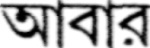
আবার
